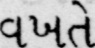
વખતે
